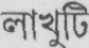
লাখুটি
